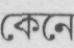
কেনে
